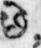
છે,
